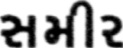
સમીર
